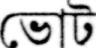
ভোট
